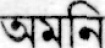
অমনি
